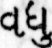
વધુ
